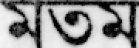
মতম
